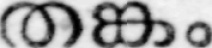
തങ്കം
